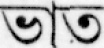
ভাত
